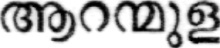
ആറന്മുള
